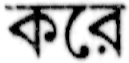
করে
